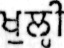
ਖੁਲ੍ਹੀ
